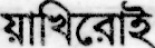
য়াখিরোই
